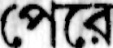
পেরে
